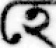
হে
